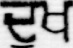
ਦੁਖ
